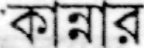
কান্নার
